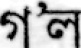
গ'ল
